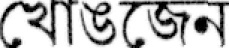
খোঙজেন
